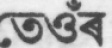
তেওঁৰ
